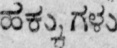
ಹಕ್ಕುಗಳು
